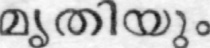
മൃതിയും
